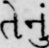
તેનું
